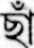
ছাঁ
